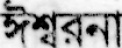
ঈশ্বরনা
